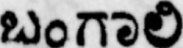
ಬಂಗಾಲಿ
